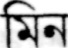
মিন
